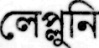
লেপ্লুনি
